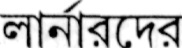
লার্নারদের
